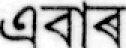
এবাৰ
